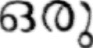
ഒരു
